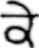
ਕੇ
